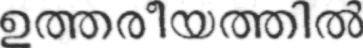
ഉത്തരീയത്തില്‍
